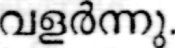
വളര്‍ന്നു
